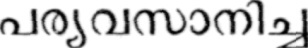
പര്യവസാനിച്ച
